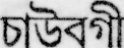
চাউবগী
